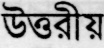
উত্তরীয়
